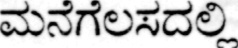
ಮನೆಗೆಲಸದಲ್ಲಿ
